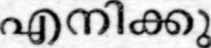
എനിക്കു
